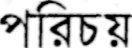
পরিচয়
